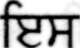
ਇਸ
